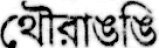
থৌরাঙঙি
